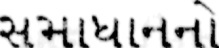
સમાધાનનો
